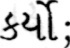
કર્યો
